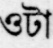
ওটা
